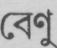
বেণু
